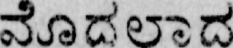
ಮೊದಲಾದ
